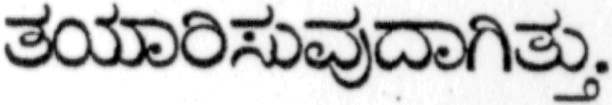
ತಯಾರಿಸುವುದಾಗಿತ್ತು.
